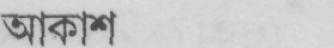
আকাশ
